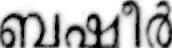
ബഷീര്‍
